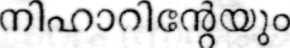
നിഹാറിന്റേയും
